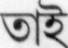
তাই
